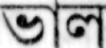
ভাল
